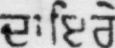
ਦਾਇਰੇ
